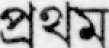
প্রথম
